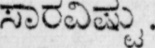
ಸಾರವಿಷ್ಟು.
